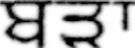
ਬੜਾ
